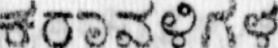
ಕರಾವಳಿಗಳ
